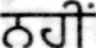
ਨਹੀਂ
